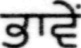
ਭਾਵੇਂ
